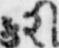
કરી
